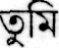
তুমি
